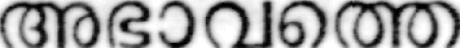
അഭാവത്തെ
